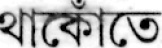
থাকোঁতে
